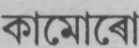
কামোৰো
